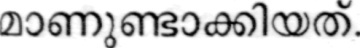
മാണുണ്ടാക്കിയത്.
